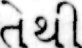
તેથી
